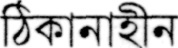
ঠিকানাহীন
